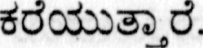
ಕರೆಯುತ್ತಾರೆ.
